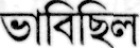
ভাবিছিল
